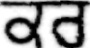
ਕਰ
